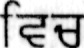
ਵਿਚ
